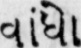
વાંધો
